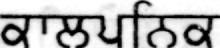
ਕਾਲਪਨਿਕ
